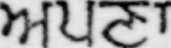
ਅਪਣਾ
